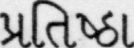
પ્રતિષ્ઠા
